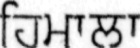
ਹਿਮਾਲਾ
